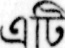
এটি
